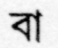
বা
